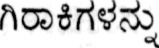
ಗಿರಾಕಿಗಳನ್ನು
